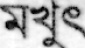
মখুৎ
